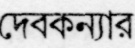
দেবকন্যার
